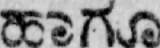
ಹಾಗೂ
